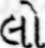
લો
